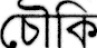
চৌকি
